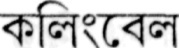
কলিংবেল
